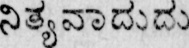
ನಿತ್ಯವಾದುದು
